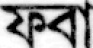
ফবা
